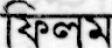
ফিলম
